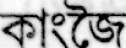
কাংজৈ
